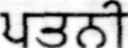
ਪਤਨੀ
